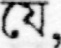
যে,
